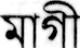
মাগী
